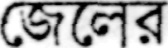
জেলের
